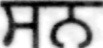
ਸਨ
